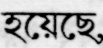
হয়েছে,
